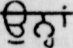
ਉਨ੍ਹਾਂ
